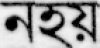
নহয়
